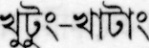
খুটুং-খাটাং
